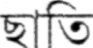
ছাতি
